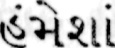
હંમેશાં
